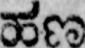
ಹಣ
